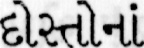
દોસ્તોનાં
